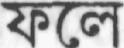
ফলে
